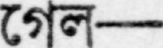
গেল—
